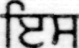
ਇਸ
